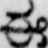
ಈ
